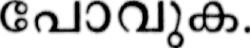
പോവുക.
